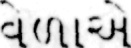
વેળાએ
